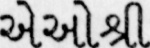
એઓશ્રી
